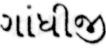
ગાંધીજી
